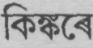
কিঙ্কৰে
